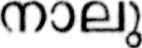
നാലു
